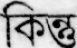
কিন্তু
